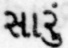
સારું
